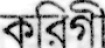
করিগী
